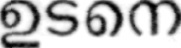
ഉടനെ
